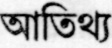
আতিথ্য
